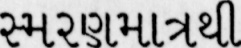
સ્મરણમાત્રથી
